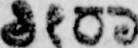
ತೀರಾ
